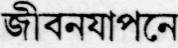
জীবনযাপনে
